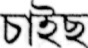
চাইছ
